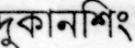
দুকানশিং
